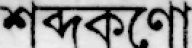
শব্দকণো
